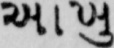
આખુ
